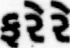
ફરેરે
